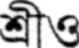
শ্রীও
